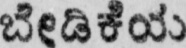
ಬೇಡಿಕೆಯ
